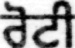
ਰੋਟੀ
